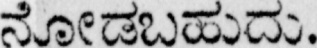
ನೋಡಬಹುದು.
